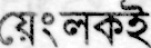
য়েংলকই
